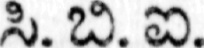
ಸಿ.ಬಿ.ಐ.
